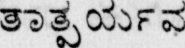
ತಾತ್ಪರ್ಯವ
